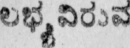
ಲಭ್ಯವಿರುವ
